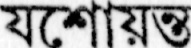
যশোয়ন্ত
